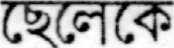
ছেলেকে
